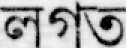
লগত
